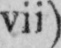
vii)
